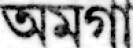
অমগা
